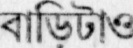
বাড়িটাও
